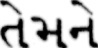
તેમને
